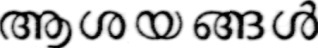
ആശയങ്ങള്‍
